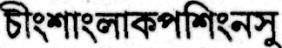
চীংশাংলাকপশিংনসু
